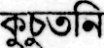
কুচুতনি
